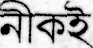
নীকই
